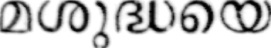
മശുദ്ധയെ
